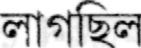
লাগছিল
